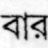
বার
